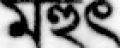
মহুৎ
